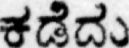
ಕಡೆದು
